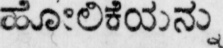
ಹೋಲಿಕೆಯನ್ನು
